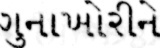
ગુનાખોરીને
